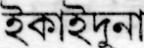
ইকাইদুনা
